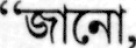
"জানো,
